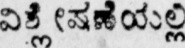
ವಿಶ್ಲೇಷಣೆಯಲ್ಲಿ
